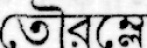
তৌরম্লে
